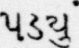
પડયું
